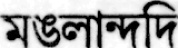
মঙলান্দদি
